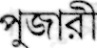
পুজারী
